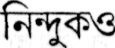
নিন্দুকও
